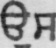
ਉਸ
